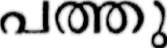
പത്തു
